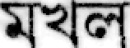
মখল
